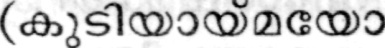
(കുടിയായ്മയോ
